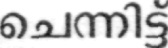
ചെന്നിട്ട്
